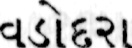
વડોદરા
